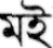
মই
